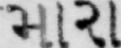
મારા
